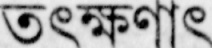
তৎক্ষণাৎ
